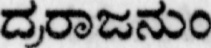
ದ್ರರಾಜನುಂ
